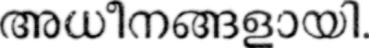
അധീനങ്ങളായി.
